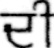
ਦੀ
